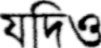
যদিও
